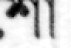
শো
